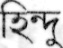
হিন্দু
